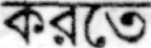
করতে
